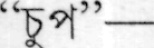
"চুপ"-
